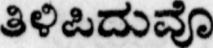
ತಿಳಿಪಿದುವೊ
